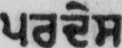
ਪਰਦੇਸ
